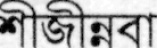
শীজীন্নবা
